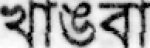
খাঙবা
